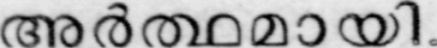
അര്‍ത്ഥമായി.
